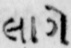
લાગે
